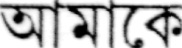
আমাকে
